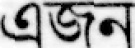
এজন
